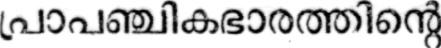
പ്രാപഞ്ചികഭാരത്തിന്റെ
